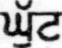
ਘੁੱਟ
